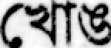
খোঙ
